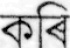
কৰি
